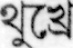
থুখ্রে
